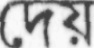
দেয়
